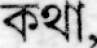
কথা,
